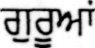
ਗੁਰੂਆਂ
